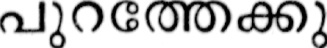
പുറത്തേക്കു
